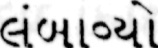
લંબાવ્યો
